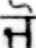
ਜੋ
